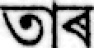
তাৰ
